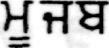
ਮੂਜਬ
